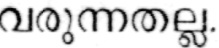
വരുന്നതല്ല.
